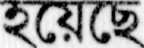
হয়েছে
